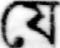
যে
